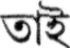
তাই
